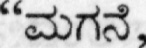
“ಮಗನೆ,
